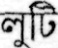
লুটি
